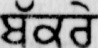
ਬੱਕਰੇ
